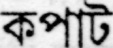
কপাট
